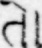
તો
